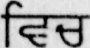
ਵਿਚ
